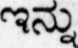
ಇನ್ನು
